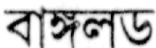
বাঙ্গলড
